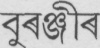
বুৰঞ্জীৰ
